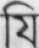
যি
